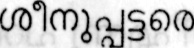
ശീനുപ്പട്ടരെ
